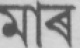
মাৰ
